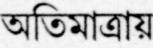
অতিমাত্রায়
